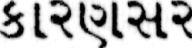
કારણસર
